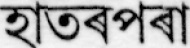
হাতৰপৰা
